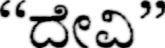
"ದೇವಿ"
